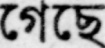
গেছে
